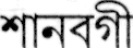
শানবগী
